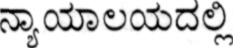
ನ್ಯಾಯಾಲಯದಲ್ಲಿ
